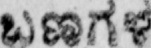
ಬಣಗಳ
